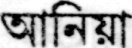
আনিয়া
